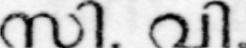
സി.വി.
